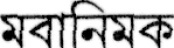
মবানিমক
